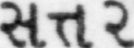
સત્તર
